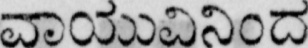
ವಾಯುವಿನಿಂದ
